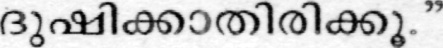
ദുഷിക്കാതിരിക്കൂ.''
